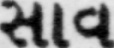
સાવ
